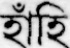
হাঁহি
